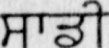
ਸਾਡੀ
